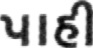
પાહી
